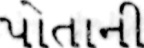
પોતાની
